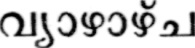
വ്യാഴാഴ്ച
